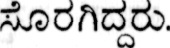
ಸೂರಗಿದ್ದರು.
